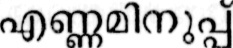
എണ്ണമിനുപ്പ്
